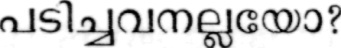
പടിച്ചവനല്ലയോ?
